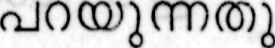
പറയുന്നതു
